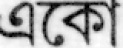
একো
